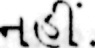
નહીં.
